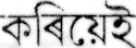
কৰিয়েই
